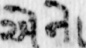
એનો
